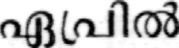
ഏപ്രില്‍
